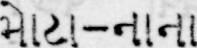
મોટા-નાના
